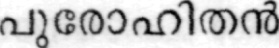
പുരോഹിതന്‍
